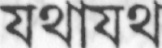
যথাযথ
